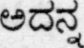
ಅದನ್ನ
